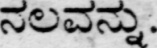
ನಲವನ್ನು.
